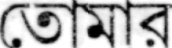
তোমার
